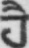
ਹੈ
